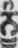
ਨੂੰ
